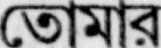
তোমার
